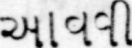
આવવી
